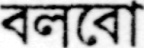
বলবো
